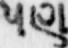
પણ
